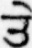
ਤੇ
